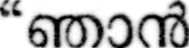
“ഞാന്‍
